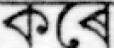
কৰে
